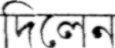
দিলেন
